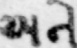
અને
